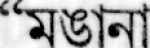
“মঙানা
